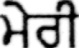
ਮੇਰੀ
